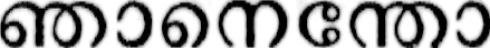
ഞാനെന്തോ
